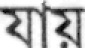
যায়
